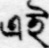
এই
